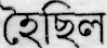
হৈছিল
